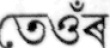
তেওঁৰ
